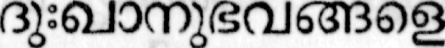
ദുഃഖാനുഭവങ്ങളെ
